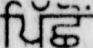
ਪਿੱਛੋਂ
